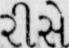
રીસે
